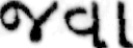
જવા
